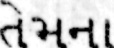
તેમના
